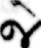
જે
